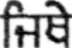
ਜਿਥੇ
